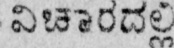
ವಿಚಾರದಲ್ಲಿ
